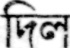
দিল
